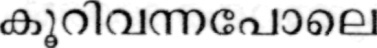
കൂറിവന്നപോലെ
